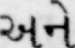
અને
